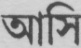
আসি
